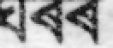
ঘৰৰ
